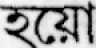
হয়ো
